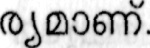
ര്യമാണ്.
